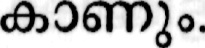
കാണും.
